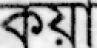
কয়া
